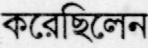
করেছিলেন
